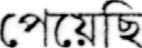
পেয়েছি
